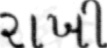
રાખી
